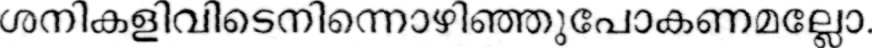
ശനികളിവിടെനിന്നൊഴിഞ്ഞുപോകണമല്ലോ.
